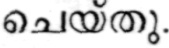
ചെയ്തു.
